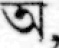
অ,
